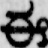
ಈ
